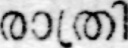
രാത്രി
